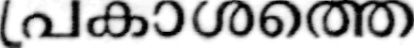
പ്രകാശത്തെ
